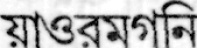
য়াওরমগনি
